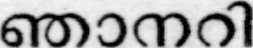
ഞാനറി
